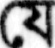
যে
